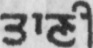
ਤਾਣੀ
